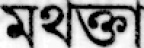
মথক্তা
